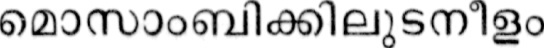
മൊസാംബിക്കിലുടനീളം
